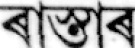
ৰাস্তাৰ
